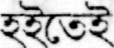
হইতেই
